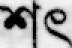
শৎ
